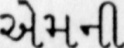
એમની
